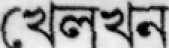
খেলখন
